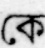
কে
